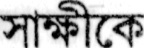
সাক্ষীকে
